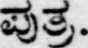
ಪುತ್ರ.
